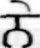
ਨੇ
